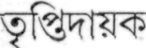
তৃপ্তিদায়ক
